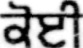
ਕੋਈ
